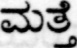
ಮತ್ತೆ
